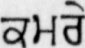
ਕਮਰੇ
